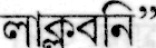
লাক্লবনি”
